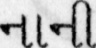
નાની
